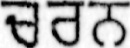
ਚਰਨ
